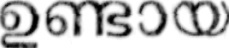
ഉണ്ടായ
